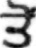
ਤੋਂ
